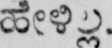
ಹೇಳಿಲ್ಲ.
